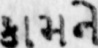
કામને
